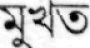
মুখত
